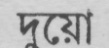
দুয়ো
